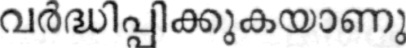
വര്‍ദ്ധിപ്പിക്കുകയാണു
